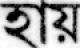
হায়
